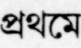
প্রথমে
